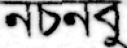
নচনবু
